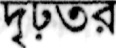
দৃঢ়তর
